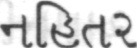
નહિતર
